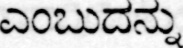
ಎಂಬುದನ್ನು
